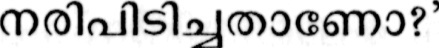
നരിപിടിച്ചതാണോ?'
